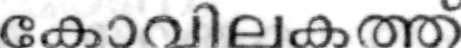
കോവിലകത്ത്
